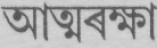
আত্মৰক্ষা
